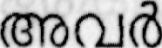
അവര്‍
